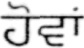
ਹੋਵਾਂ
